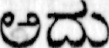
ಅದು
